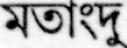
মতাংদু
